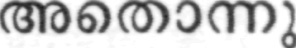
അതൊന്നു
